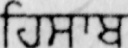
ਹਿਸਾਬ
